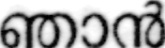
ഞാന്‍
